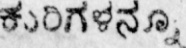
ಕುರಿಗಳನ್ನೂ
